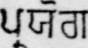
ਪ੍ਰਯੋਗ
